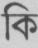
কি
